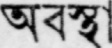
অবস্থা
